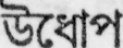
উধোপ
